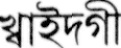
খ্বাইদগী
